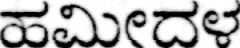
ಹಮೀದಳ
